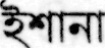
ইশানা
